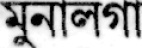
মুনালগা
